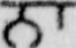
ਨਾ
